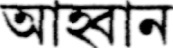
আহ্বান
